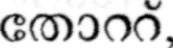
തോററ്,
